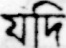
যদি
